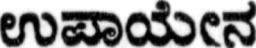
ಉಪಾಯೇನ
